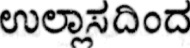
ಉಲ್ಲಾಸದಿಂದ
